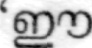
‘ഈ
